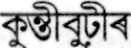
কুন্তীবুঢ়ীৰ
